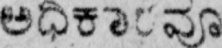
ಅಧಿಕಾರವೂ
